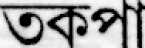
তকপা
